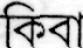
কিবা
